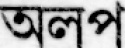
অলপ
